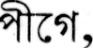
পীগে,
